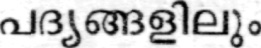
പദ്യങ്ങളിലും
